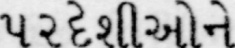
પરદેશીઓને
